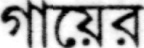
গায়ের
